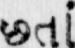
છતાં
